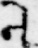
ને
